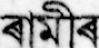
ৰামীৰ
